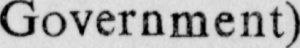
Government)
